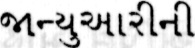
જાન્યુઆરીની
